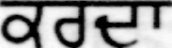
ਕਰਦਾ
